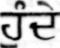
ਹੁੰਦੇ
